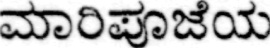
ಮಾರಿಪೂಜೆಯ
